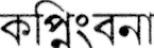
কপ্নিংবনা
